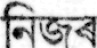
নিজৰ
